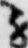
કે
